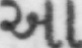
આ
